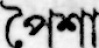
পৈশা
